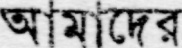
আমাদের
